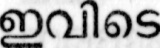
ഇവിടെ
